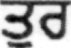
ਤੁਰ
